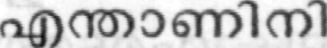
എന്താണിനി
